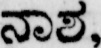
ನಾಶ,
